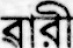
ৱারী
